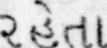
રહેતા
